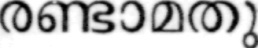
രണ്ടാമതു
